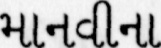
માનવીના
